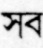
সব
